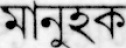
মানুহক
